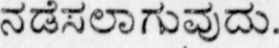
ನಡೆಸಲಾಗುವುದು.
